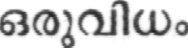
ഒരുവിധം
